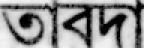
তাবদা
